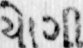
યોગી
